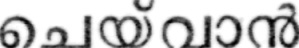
ചെയ്വാന്‍
